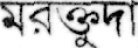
মরক্তুদা
